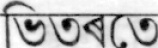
ভিতৰতে
